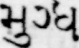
મુગ્ધ
